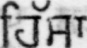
ਹਿੱਸਾ
